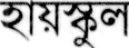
হায়স্কুল
